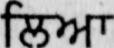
ਲਿਆ
